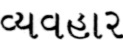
વ્યવહાર
